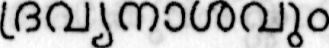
ദ്രവ്യനാശവും
